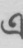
এ
